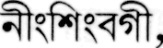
নীংশিংবগী,
